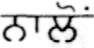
ਨਾਲੋਂ
